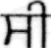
ਸੀ
